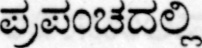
ಪ್ರಪಂಚದಲ್ಲಿ
